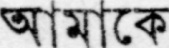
আমাকে
